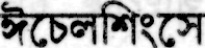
ঈচেলশিংসে
